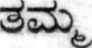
ತಮ್ಮ
